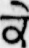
ਕੇ
